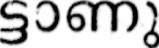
ട്ടാണു
